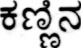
ಕಣ್ಣಿನ
